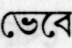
ভেবে
